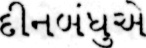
દીનબંધુએ
